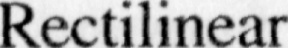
Rectilinear
